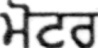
ਮੋਟਰ
